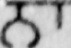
ਨਾ
